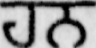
ਹਨ
